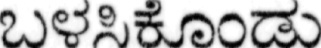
ಬಳಸಿಕೊಂಡು
